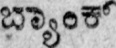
ಬ್ಯಾಂಕ್
